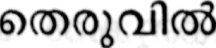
തെരുവില്‍
